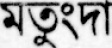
মতুংদা
